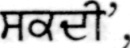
ਸਕਦੀ',
